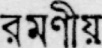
রমণীয়
